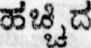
ಹಚ್ಚಿದ
